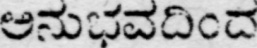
ಅನುಭವದಿ೦ದ
